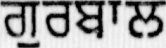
ਗੁਰਬਾਲ
